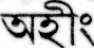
অহীং
